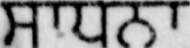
ਸਾਧਨਾ
